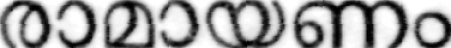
രാമായണം
